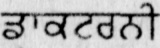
ਡਾਕਟਰਨੀ
